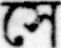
সে
